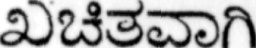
ಖಚಿತವಾಗಿ
